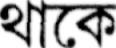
থাকে
